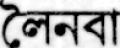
লৈনবা
